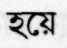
হয়ে
